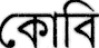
কোবি
